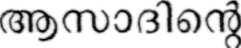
ആസാദിന്റെ
